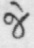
જે
